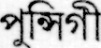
পুন্সিগী
